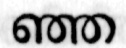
ഞ്ഞ
